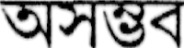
অসম্ভব
